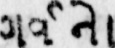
ગર્વનો
